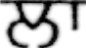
ਲਾ
